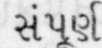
સંપૂર્ણ
